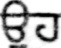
ਉਹ
